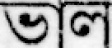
ভাল
